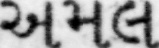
અમલ
